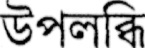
উপলব্ধি
